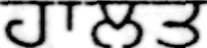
ਹਾਲਤ
